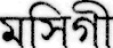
মসিগী
